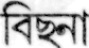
বিছনা
